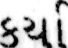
કર્યા
